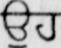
ਉਹ
